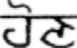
ਹੋਣ
